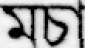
মচা
